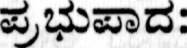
ಪ್ರಭುಪಾದ:
